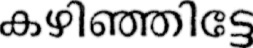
കഴിഞ്ഞിട്ടേ
